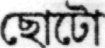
ছোটো
